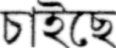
চাইছে
